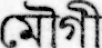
মৌগী
